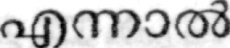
എന്നാല്‍
